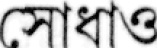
সোধাও
